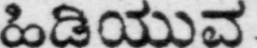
ಹಿಡಿಯುವ
